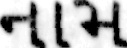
નામ
